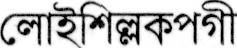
লোইশিল্লকপগী
